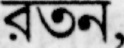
রতন,
